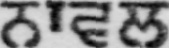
ਨਾਵਲ
